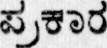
ಪ್ರಕಾರ
